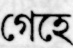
গেহে
